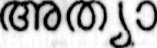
അത്യാ
